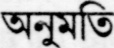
অনুমতি
